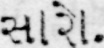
સારો.
